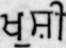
ਖੁਸ਼ੀ
